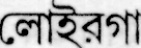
লোইরগা
